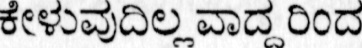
ಕೇಳುವುದಿಲ್ಲವಾದ್ದರಿಂದ
